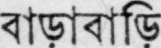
বাড়াবাড়ি
